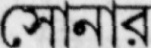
সোনার
